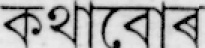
কথাবোৰ
